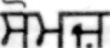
ਸੋਮਜ਼
